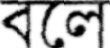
বলে
